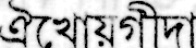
ঐখোয়গীদা
